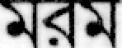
মরম
